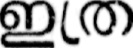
ഇത്ര
